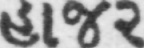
હાજર
